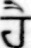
ਹੈ
